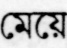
মেয়ে
